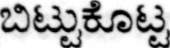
ಬಿಟ್ಟುಕೊಟ್ಟ
